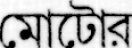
মোটোর
